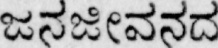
ಜನಜೀವನದ
